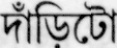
দাঁড়িটো
